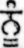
ਨੂੰ
